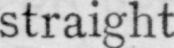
straight
